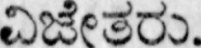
ವಿಜೇತರು.
